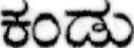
ಕಂಡು
